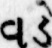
વડે
